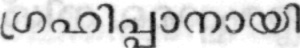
ഗ്രഹിപ്പാനായി
